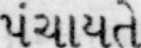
પંચાયતે
